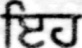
ਇਹ
